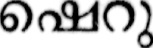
ഷെറു
